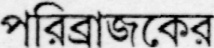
পরিব্রাজকের
